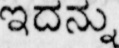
ಇದನ್ನು
